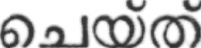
ചെയ്ത്
